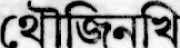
থৌজিনখি
